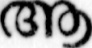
ആ
